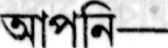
আপনি-
